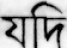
যদি
